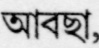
আবছা,
